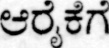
ಆರೈಕೆಗೆ
